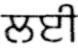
ਲਈ
